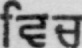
ਵਿਚ
